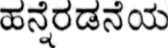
ಹನ್ನೆರಡನೆಯ
